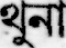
থুনা
